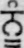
ਨੂੰ
